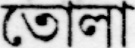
তোলা
